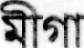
মীগা
